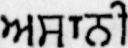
ਅਸਾਨੀ
